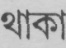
থাকা
